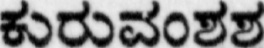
ಕುರುವಂಶಶ
